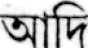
আদি
